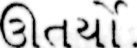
ઊતર્યો.
